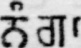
ਨੰਗਾ
